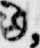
છે,
